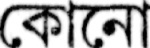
কোনো
